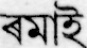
ৰমাই
